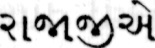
રાજાજીએ
